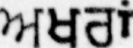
ਅਖਰਾਂ
